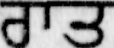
ਰਾਤ
